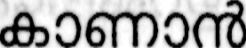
കാണാന്‍
